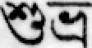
শুভ্র
